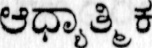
ಆಧ್ಯಾತ್ಮಿಕ
